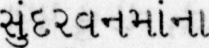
સુંદરવનમાંના
